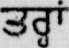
ਤਰ੍ਹਾਂ
